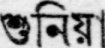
শুনিয়া
